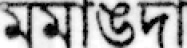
মমাঙদা
